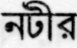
নটীর
